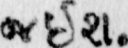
જઈશ.
